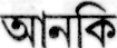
আনকি
